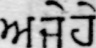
ਅਜੇਹੇ
